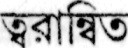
ত্বরান্বিত
